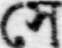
সে
